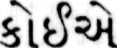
કોઈએ
